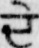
ਦੇ
